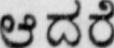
ಆದರೆ
